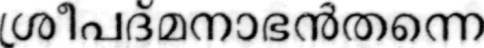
ശ്രീപദ്മനാഭന്‍തന്നെ
